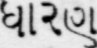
ધારણ
